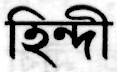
হিন্দী
